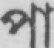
পা
